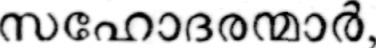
സഹോദരന്മാര്‍,
